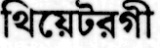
থিয়েটরগী
